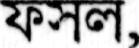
ফসল,
